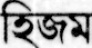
হিজম
